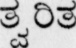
ತ್ವರಿತ
